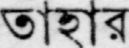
তাহার
